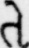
તે
